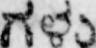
ಗಳು
